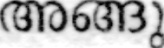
അങ്ങു
